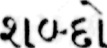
શબ્દો
